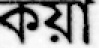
কয়া
